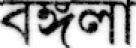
বঙ্গলা
